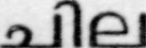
ചില
